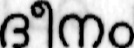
ദീനം
